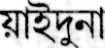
য়াইদুনা
